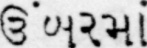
ઉંબરમાં
